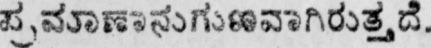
ಪ್ರಮಾಣಾನುಗುಣವಾಗಿರುತ್ತದೆ.
